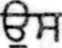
ਉਸ
